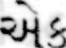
એક
